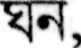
ঘন,
